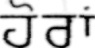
ਹੋਰਾਂ
